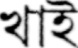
খাই
